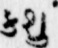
કશું
